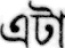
এটা
